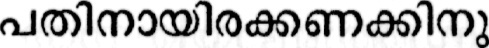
പതിനായിരക്കണക്കിനു
